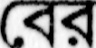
বের
